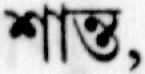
শান্ত,
